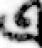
এ
